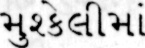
મુશ્કેલીમાં
